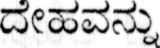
ದೇಹವನ್ನು
